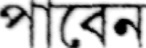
পাবেন
